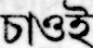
চাওই
